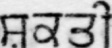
ਸ਼ਕਤੀ
